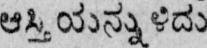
ಆಸ್ತಿಯನ್ನುಳಿದು
